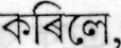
কৰিলে,
